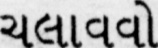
ચલાવવો
